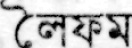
লৈফম
